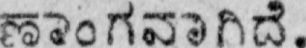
ಣಾಂಗವಾಗಿದೆ.
